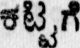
ಕಟ್ಟಿಗೆ
